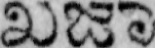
ಖಜಾ
